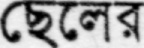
ছেলের
